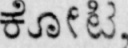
ಕೋಟಿ,
